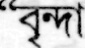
“বন্দা
